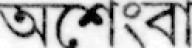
অশেংবা
